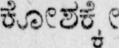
ಕೋಶಕ್ಕೇ
